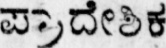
ಪ್ರಾದೇಶಿಕ
